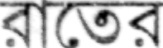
রাতের
